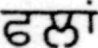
ਫਲਾਂ
